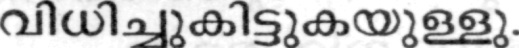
വിധിച്ചുകിട്ടുകയുള്ളു.
